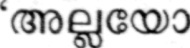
‘അല്ലയോ
